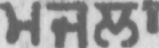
ਮਜਲਾ
